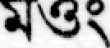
মওং
